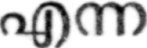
എന്ന
